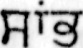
ਸਾਂਭ
